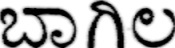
ಬಾಗಿಲ
